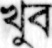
খুব
